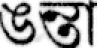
ঙন্তা
